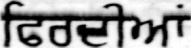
ਫਿਰਦੀਆਂ
